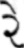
રે
